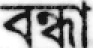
বন্ধা
